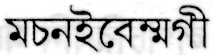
মচনইবেম্মগী
